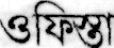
ওফিস্তা
